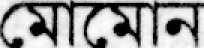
মোমোন
